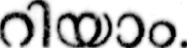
റിയാം.
